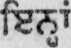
ਇਨ੍ਹਾਂ
